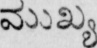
ಮುಖ್ಯ
